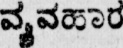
ವ್ಯವಹಾರ
